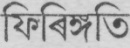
ফিৰিঙ্গতি
